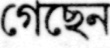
গেছেন
